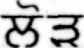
ਲੋੜ
